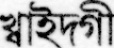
খ্বাইদগী
